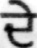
ਦੇ
